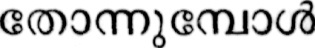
തോന്നുമ്പോള്‍
